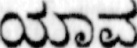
ಯಾವ
